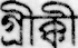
গ্রীক্কী
